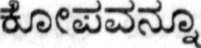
ಕೋಪವನ್ನೂ
